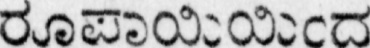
ರೂಪಾಯಿಯಿಂದ
